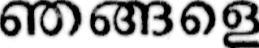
ഞങ്ങളെ
